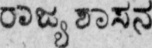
ರಾಜ್ಯಶಾಸನ
